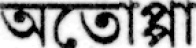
অতোপ্পা
